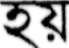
হয়
